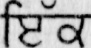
ਇੱਕ
